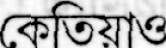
কেতিয়াও
